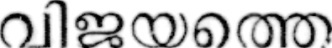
വിജയത്തെ
